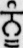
ਨੂੰ
